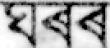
ঘৰৰ
